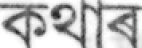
কথাৰ
